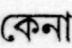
কেনা
